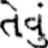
તેવું
